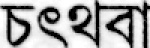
চৎথবা
